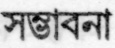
সম্ভাবনা
